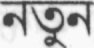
নতুন
